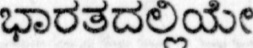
ಭಾರತದಲ್ಲಿಯೇ
